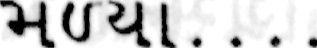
મળ્યા....
